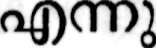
എന്നു
